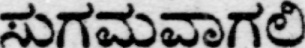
ಸುಗಮವಾಗಲಿ
